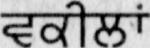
ਵਕੀਲਾਂ
